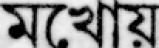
মখোয়
